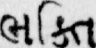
ભક્તિ
